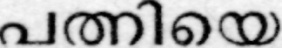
പത്നിയെ
